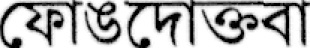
ফোঙদোক্তবা
